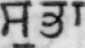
ਸੁਭਾ
